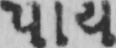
પાય
